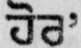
ਹੋਰ'
